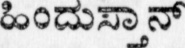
ಹಿಂದುಸ್ತಾನ್
